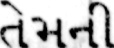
તેમની
